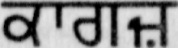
ਕਾਗਜ਼
